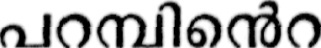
പറമ്പിന്റെ
